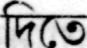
দিতে
